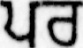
ਪਰ
